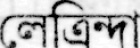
লেত্রিন্দা
